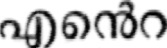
എന്റെ
